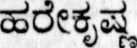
ಹರೇಕೃಷ್ಣ
